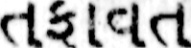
તફાવત
